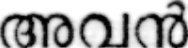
അവന്‍
